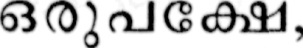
ഒരുപക്ഷേ,
